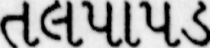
તલપાપડ
